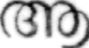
ആ
